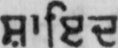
ਸ਼ਾਇਦ
